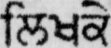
ਲਿਖਕੇ
